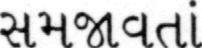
સમજાવતાં
